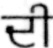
ਦੀ
